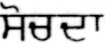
ਸੋਚਦਾ
